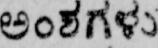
ಅಂಶಗಳು
